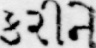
કરીને
